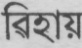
ৱিহায়
